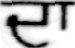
ਦਾ
